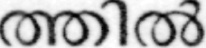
ത്തില്‍
